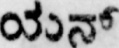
ಯನ್
